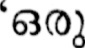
‘ഒരു
